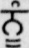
ਨੂੰ
